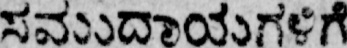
ಸಮುದಾಯಗಳಿಗೆ
